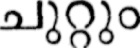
ചുറ്റും
